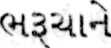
ભરૂચાને
